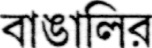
বাঙালির
